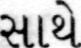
સાથે
